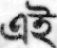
এই
